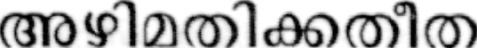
അഴിമതിക്കതീത
